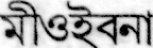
মীওইবনা
